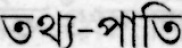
তথ্য-পাতি
